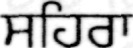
ਸਹਿਰਾ
